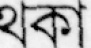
থকা
